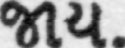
જાય.
